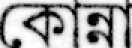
কোন্না
